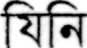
যিনি
